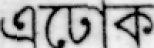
এঢোক
